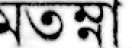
মতম্না
